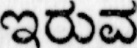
ಇರುವ
